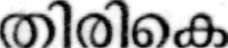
തിരികെ
